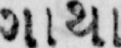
ગાથા
